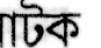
নাটক
